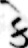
કે
